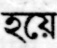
হয়ে
